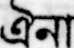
ঐনা
